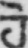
ਹੋ
